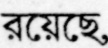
রয়েছে,
